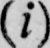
(i)
